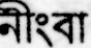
নীংবা
